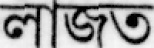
লাজত
